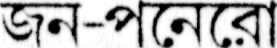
জন-পনেরো
